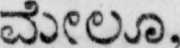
ಮೇಲೂ,
